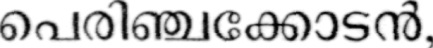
പെരിഞ്ചക്കോടന്‍,
